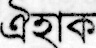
ঐহাক
